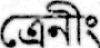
ত্রেনীং
